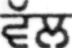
ਵੱਲ
